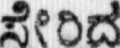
ಸೇರಿದ
